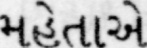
મહેતાએ
